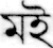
মই
